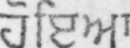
ਹੋਇਆ
